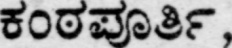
ಕಂಠಪೂರ್ತಿ,
